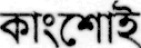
কাংশোই
